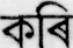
কৰি
